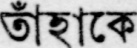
তাঁহাকে
